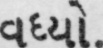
વધ્યો.
